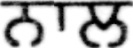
ਨਾਲ
